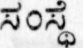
ಸಂಸ್ಥೆ
